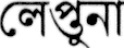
লেপ্তুনা
